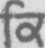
ਕਿ
